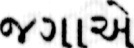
જગાએ
